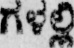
ಗಳಲ್ಲಿ
